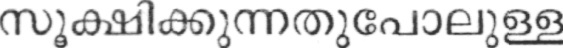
സൂക്ഷിക്കുന്നതുപോലുള്ള
